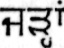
ਜੜ੍ਹਾਂ
